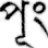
পূং
